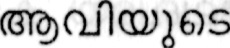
ആവിയുടെ
